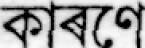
কাৰণে
